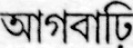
আগবাঢ়ি
